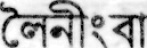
লৈনীংবা
